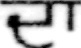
ਦਾ
